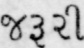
જરૂરી
